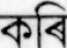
কৰি
